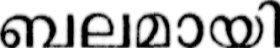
ബലമായി
